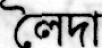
লৈদা
